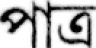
পাত্র
